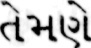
તેમણે
